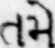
તમે
